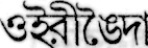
ওইরীঙৈদা
